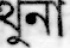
থুনা
